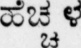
ಹೆಚ್ಚಳ
